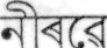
নীৰৱে
